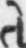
તે
